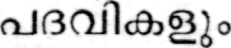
പദവികളും
